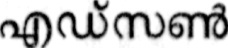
എഡ്സണ്‍
